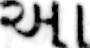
આ
